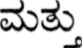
ಮತ್ತು
